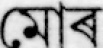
মোৰ
